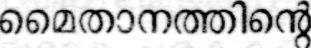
മൈതാനത്തിന്റെ
